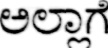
ಅಲ್ಲಾಗೆ
